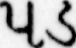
પડ
